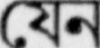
যেন
